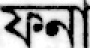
ফনা
